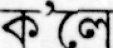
ক'লে
